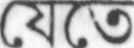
যেতে
